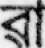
ৱা
